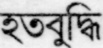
হতবুদ্ধি
